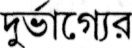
দুর্ভাগ্যের
